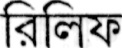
রিলিফ
